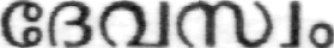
ദേവസ്വം
